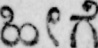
ಹೀಗೆ
